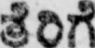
ತೆರಿಗೆ
